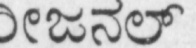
ರೀಜನಲ್
